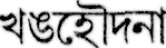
খঙহৌদনা
